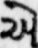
એ
